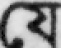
যে
